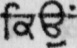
ਕਿਉਂ
